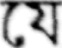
যে
